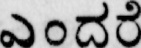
ಎಂದರೆ
